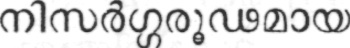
നിസര്‍ഗ്ഗരൂഢമായ
